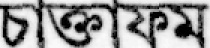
চাক্তাফম
